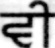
ਵੀ
